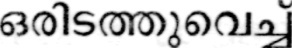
ഒരിടത്തുവെച്ച്
